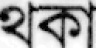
থকা
